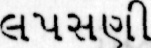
લપસણી
